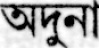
অদুনা
